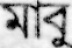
মাবু
